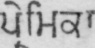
ਪ੍ਰੇਮਿਕਾ
